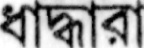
ধাদ্ধারা
